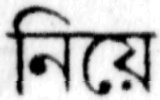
নিয়ে
